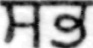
ਸਭ
